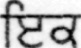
ਇਕ
